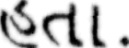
હતા.
